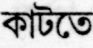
কাটতে
